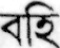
বহি
